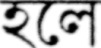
হলে
